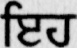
ਇਹ
